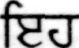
ਇਹ
